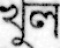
খুল
